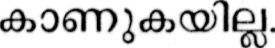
കാണുകയില്ല.
